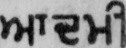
ਆਦਮੀ
